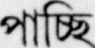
পাচ্ছি
